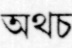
অথচ
